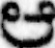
ಆ
